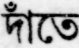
দাঁতে
